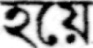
হয়ে
